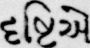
દષ્ટિએ
